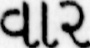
વાર
